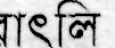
ৱাৎলি
